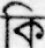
কি
